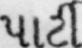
પાર્ટી
